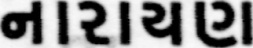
નારાયણ
